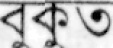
বুকুত
